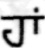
ਹਾਂ
